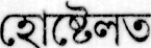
হোষ্টেলত
